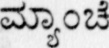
ಮ್ಯಾಂಚೆ
